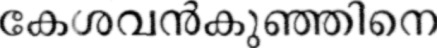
കേശവന്‍കുഞ്ഞിനെ
